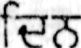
ਦਿਨ
